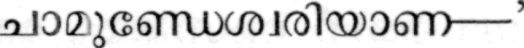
ചാമുണ്ഡേശ്വരിയാണ-'
